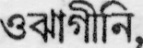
ওঝাগীনি,
